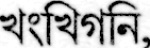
খংখিগনি,
